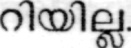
റിയില്ല.
